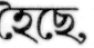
হৈছে,
